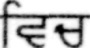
ਵਿਚ
